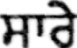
ਸਾਰੇ
